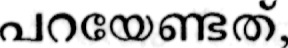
പറയേണ്ടത്,
